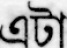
এটা
